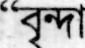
“বৃন্দা
